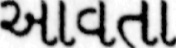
આવતા
